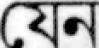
যেন
